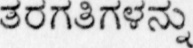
ತರಗತಿಗಳನ್ನು
